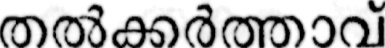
തല്‍ക്കര്‍ത്താവ്
